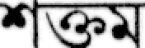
শক্তম
